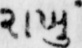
રાખું
